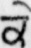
ਕੇ
